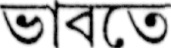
ভাবতে
